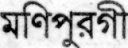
মণিপুরগী
